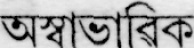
অস্বাভাৱিক
